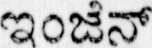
ಇಂಜೆನ್
